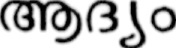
ആദ്യം
